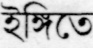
ইঙ্গিতে
